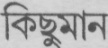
কিছুমান
